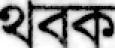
অম-’ম
